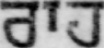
ਰਾਹ
